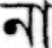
না
